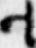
ન
